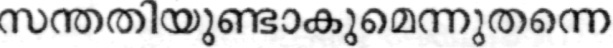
സന്തതിയുണ്ടാകുമെന്നുതന്നെ
